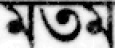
মতম
